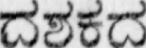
ದಶಕದ
